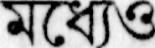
মধ্যেও
